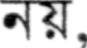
নয়,
